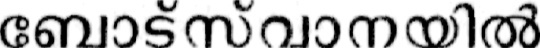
ബോട്സ്വാനയില്‍
